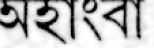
অহাংবা
